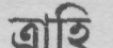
ত্ৰাহি
